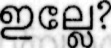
ഇല്ലേ?
